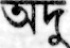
অদু
